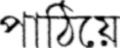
পাঠিয়ে
